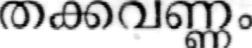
തക്കവണ്ണം
